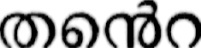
തന്റെ
